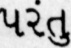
પરંતુ
